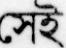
সেই
